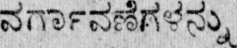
ವರ್ಗಾವಣೆಗಳನ್ನು
